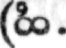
(ಹಿ.
